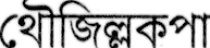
থৌজিল্লকপা
